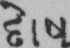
દોષ
